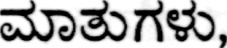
ಮಾತುಗಳು,
